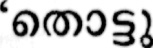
‘തൊട്ടു
